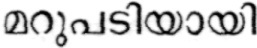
മറുപടിയായി
